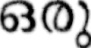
ഒരു
